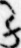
કે
